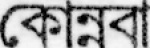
কোন্নবা
